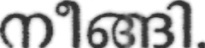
നീങ്ങി.
